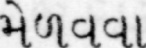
મેળવવા
